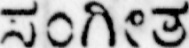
ಸಂಗೀತ
